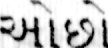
ઓછો
